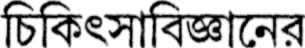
চিকিৎসাবিজ্ঞানের
